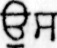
ਉਸ
